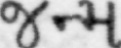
જન્મ
